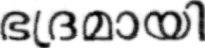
ഭദ്രമായി
